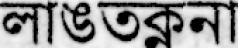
লাঙতক্ননা
